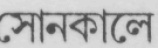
সোনকালে
